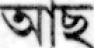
আছ
